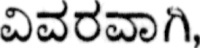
ವಿವರವಾಗಿ,
